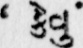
'કેવું
